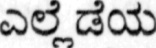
ಎಲ್ಲೆಡೆಯ
